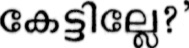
കേട്ടില്ലേ?’
